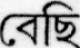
বেছি
